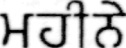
ਮਹੀਨੇ
